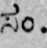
ಸಂ.
